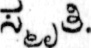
ಸ್ಮೃತಿ.
